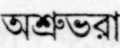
অশ্রুভরা
